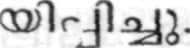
യിപ്പിച്ചു.
